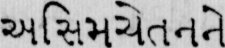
અસિમચેતનને
